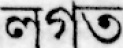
লগত
